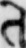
તે
